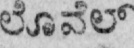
ಲೊವೆಲ್
